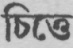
চিত্তে
